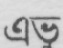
এভু
